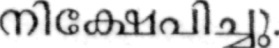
നിക്ഷേപിച്ചു.
